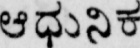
ಆಧುನಿಕ
